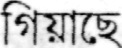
গিয়াছে
